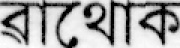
ৱাথোক
